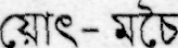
য়োৎ-মচৈ
